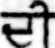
ਦੀ
